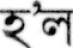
হ'ল
